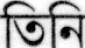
তিনি
